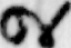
જ
